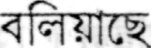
বলিয়াছে
